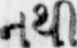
નથી
